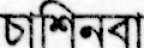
চাশিনবা
